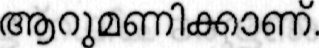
ആറുമണിക്കാണ്.
